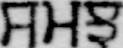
ਸਮਝ
